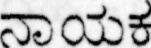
ನಾಯಕ
